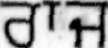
ਰਾਜ
